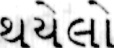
થયેલો
